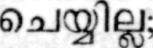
ചെയ്യില്ല;
